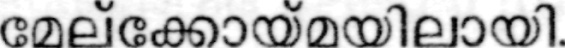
മേല്ക്കോയ്മയിലായി.
